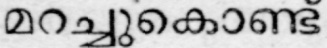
മറച്ചുകൊണ്ട്
